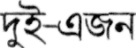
দুই-এজন
